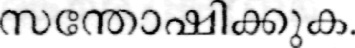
സന്തോഷിക്കുക.
